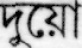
দুয়ো
